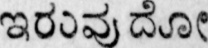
ಇರುವುದೋ
